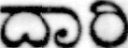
ದಾರಿ
